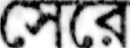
সেরে
